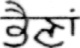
ਭੈਣਾਂ
